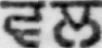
ਵਲ
